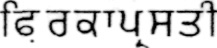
ਫ਼ਿਰਕਾਪ੍ਰਸਤੀ
